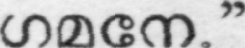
ഗമനേ.”
